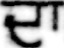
ਦਾ
